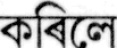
কৰিলে
